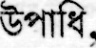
উপাধি,
